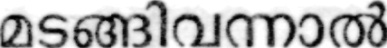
മടങ്ങിവന്നാല്‍
